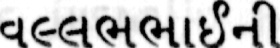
વલ્લભભાઈની
